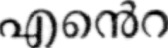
എന്റെ
